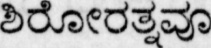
ಶಿರೋರತ್ನವೂ
